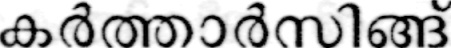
കര്‍ത്താര്‍സിങ്ങ്
